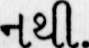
નથી.
